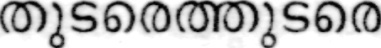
തുടരെത്തുടരെ
